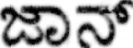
ಜಾನ್
